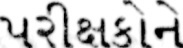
પરીક્ષકોને
